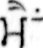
ਮੈਂ
